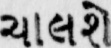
ચાલશે
